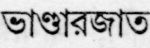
ভাণ্ডারজাত
